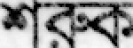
শরুক
